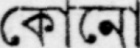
কোনো
